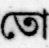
তো
